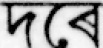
দৰে
